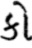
કો
